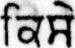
ਕਿਸੇ
